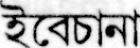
ইবেচানা
